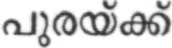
പുരയ്ക്ക്
